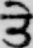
ਤੇ
